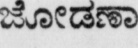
ಜೋಡಣಾ
